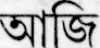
আজি
